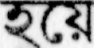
হয়ে
